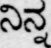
ನಿನ್ನ
